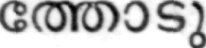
ത്തോടു
